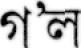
গ'ল
